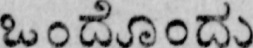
ಒಂದೊಂದು
